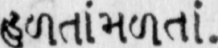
હળતાંમળતાં.
